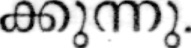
ക്കുന്നു.
